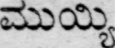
ಮುಯ್ಯಿ
